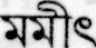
মমীৎ
